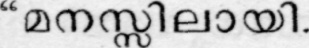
"മനസ്സിലായി.
